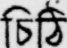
চিঠি
